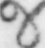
જ
